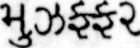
મુઝફ્ફર
